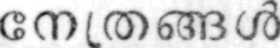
നേത്രങ്ങള്‍
